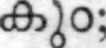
കും;
